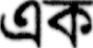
এক
